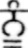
ਨੂੰ
